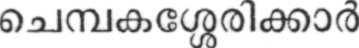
ചെമ്പകശ്ശേരിക്കാര്‍
